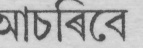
আচৰিবে
